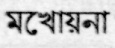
মখোয়না
